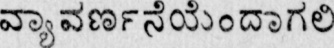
ವ್ಯಾವರ್ಣನೆಯೆಂದಾಗಲಿ
